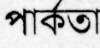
পার্কতা
